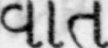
વાત
